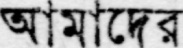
আমাদের
